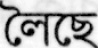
লৈছে
